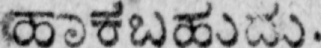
ಹಾಕಬಹುದು.
